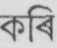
কৰি
